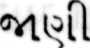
જાણી
